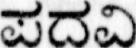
ಪದವಿ
